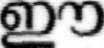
ഈ
